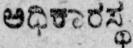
ಅಧಿಕಾರಸ್ಥ
